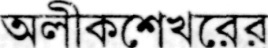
অলীকশেখরের
